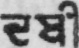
ਦਬੀ
